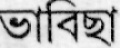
ভাবিছা
